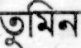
তুমিন
